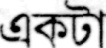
একটা
